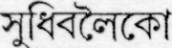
সুধিবলৈকো
